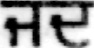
ਜਦ
